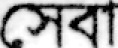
সেবা
